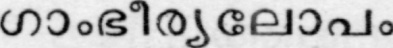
ഗാംഭീര്യലോപം
